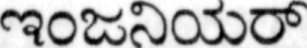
ಇಂಜನಿಯರ್
